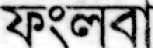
ফংলবা
